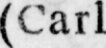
(Carl
